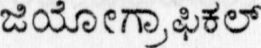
ಜಿಯೋಗ್ರಾಫಿಕಲ್
